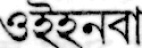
ওইহনবা
